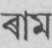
ৰাম
